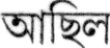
আছিল
